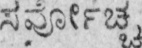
ಸರ್ವೋಚ್ಚ
